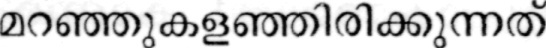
മറഞ്ഞുകളഞ്ഞിരിക്കുന്നത്
